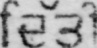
ਦਿੱਤੀ
